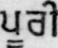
ਪੂਰੀ
